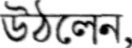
উঠলেন,
